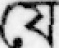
যে
